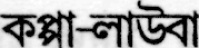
কন্না-লাউবা
